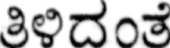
ತಿಳಿದಂತೆ
